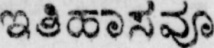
ಇತಿಹಾಸವೂ
